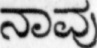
ನಾವು
